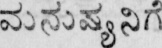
ಮನುಷ್ಯನಿಗೆ
